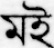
মই
